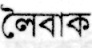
লৈবাক
